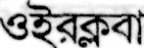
ওইরক্লবা
